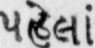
પહેલાં
